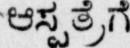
ಆಸ್ಪತ್ರೆಗೆ
